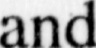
and
